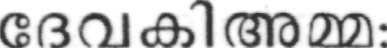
ദേവകിഅമ്മ:
